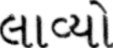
લાવ્યો
